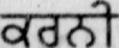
ਕਰਨੀ
